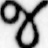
જ
